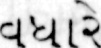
વધારે
